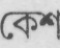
কেশ
